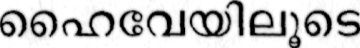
ഹൈവേയിലൂടെ
